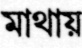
মাথায়
